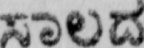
ಸಾಲದ
